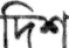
দিশ
